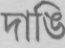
দাঙি
